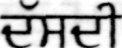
ਦੱਸਦੀ
